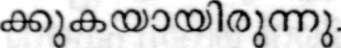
ക്കുകയായിരുന്നു.
